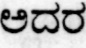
ಅದರ
